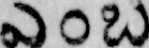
ಎಂಬ
